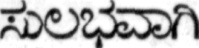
ಸುಲಭವಾಗಿ
